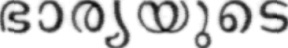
ഭാര്യയുടെ
